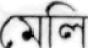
মেলি
